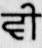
ਵੀ
